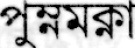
পুম্নমক্না
